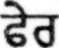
ਫੇਰ
